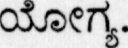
ಯೋಗ್ಯ.
